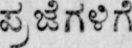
ಪ್ರಜೆಗಳಿಗೆ
